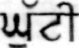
ਘੁੱਟੀ
